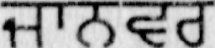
ਜਾਨਵਰ
